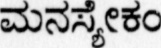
ಮನಸ್ಯೇಕಂ
